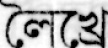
লৈখ্রে
